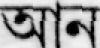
আন
